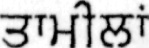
ਤਾਮੀਲਾਂ
